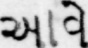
આવે
